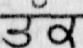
ਤੱਕ
